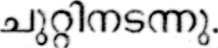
ചുറ്റിനടന്നു.
